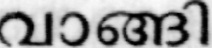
വാങ്ങി
